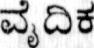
ವೈದಿಕ
